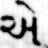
એ
